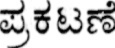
ಪ್ರಕಟಣೆ
